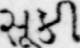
સૂકી
